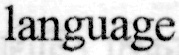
language
